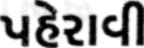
પહેરાવી
